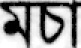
মচা
